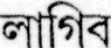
লাগিব
